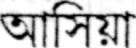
আসিয়া
